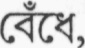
বেঁধে,
